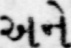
અને
